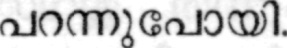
പറന്നുപോയി.
